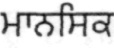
ਮਾਨਸਿਕ
